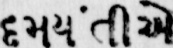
દમયંતીએ
